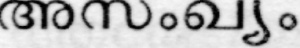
അസംഖ്യം
